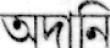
অদানি
